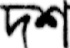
দশ
